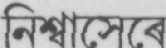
নিশ্বাসেৰে
